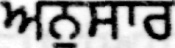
ਅਨੁਸਾਰ
